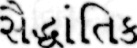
સૈદ્ધાંતિક
